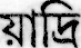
য়াদ্রি
